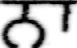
ਨਾ
